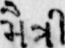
મૈત્રી
